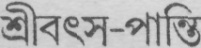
শ্ৰীবৎস-পান্তি
